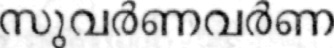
സുവര്‍ണവര്‍ണ
